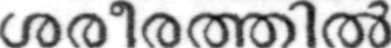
ശരീരത്തില്‍
